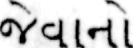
જેવાનો
